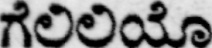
ಗೆಲಿಲಿಯೊ
